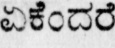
ಏಕೆಂದರೆ
